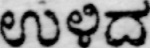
ಉಳಿದ
